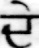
ਦੇ
